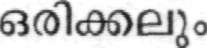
ഒരിക്കലും
